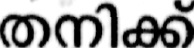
തനിക്ക്
